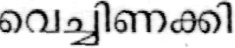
വെച്ചിണക്കി
